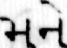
મને
